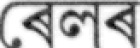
ৰেলৰ
